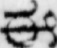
ಈ
